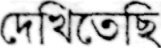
দেখিতেছি
